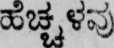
ಹೆಚ್ಚಳವು
